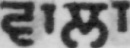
ਵਾਲਾ
